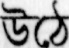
উঠে
